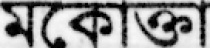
মকোক্তা
